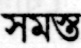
সমস্ত
